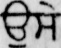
ਉਸੇ
